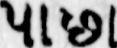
પાછા
